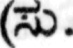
(ಸು.
